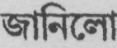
জানিলো
